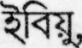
ইবিয়ু,
